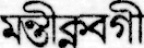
মন্তীক্নবগী
